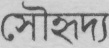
সৌহৃদ্য
